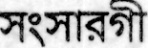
সংসারগী
